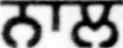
ਨਾਲ
